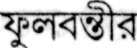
ফুলবন্তীর
